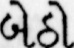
બેઠો
